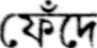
ফেঁদে
